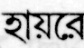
হায়রে
